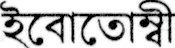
ইবোতোম্বী
